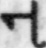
ન
